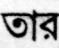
তার
